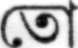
তো
